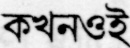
কখনওই
